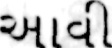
આવી
